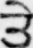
ਤੇ
